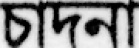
চাদনা
